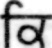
ਕਿ
